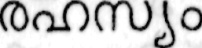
രഹസ്യം
